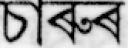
চাৰুৰ
